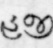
હજી
